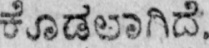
ಕೊಡಲಾಗಿದೆ.
